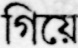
গিয়ে
